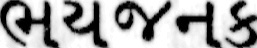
ભયજનક
